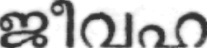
ജീവഹ
